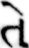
તે
